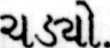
ચડ્યો.
